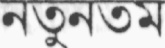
নতুনতম
